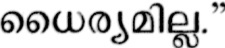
ധൈര്യമില്ല.”
